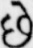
છે
